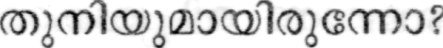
തുനിയുമായിരുന്നോ?
